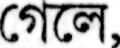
গেলে,
